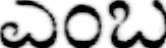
ಎಂಬ
